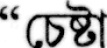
"চেষ্টা
